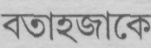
বতাহজাকে
